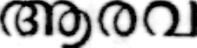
ആരവ
